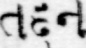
તદ્દન
